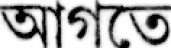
আগতে
